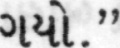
ગયો.”
